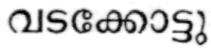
വടക്കോട്ടു
